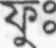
ফুঃ
